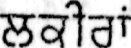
ਲਕੀਰਾਂ
